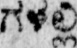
ಗಳಲ್ಲಿ
